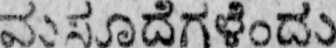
ಮಸೂದೆಗಳೆಂದು
